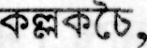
কল্লকচৈ,
